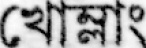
খোম্লাং
